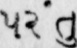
પરંતુ
